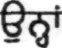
ਉਨ੍ਹਾਂ
